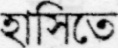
হাসিতে
